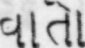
વાતો
